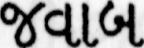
જવાબ
